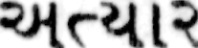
અત્યાર
